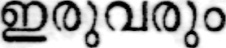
ഇരുവരും
